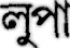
লুপা
